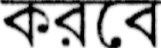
করবে
